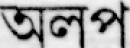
অলপ
